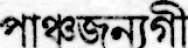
পাঞ্চজন্যগী
